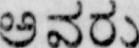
ಅವರು
